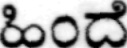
ಹಿಂದೆ
